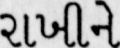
રાખીને
